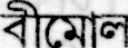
বীমোল
